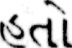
હતો
